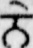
ਨੇ
